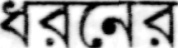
ধরনের
